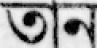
তান
